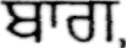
ਬਾਗ,
